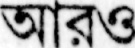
আরও
